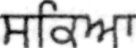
ਸਕਿਆ
